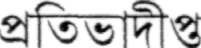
প্রতিভাদীপ্ত
